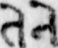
તેને
